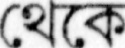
থেকে
